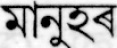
মানুহৰ
